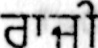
ਰਾਜੀ
